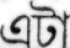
এটা
